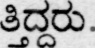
ತ್ತಿದ್ದರು.
